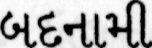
બદનામી
